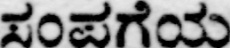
ಸಂಪಗೆಯ
